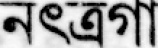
নৎত্রগা
